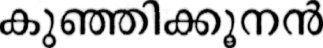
കുഞ്ഞിക്കൂനന്‍
